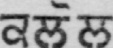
ਕਲੋਲ
